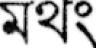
মথং
